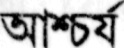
আশ্চর্য
